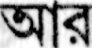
আর
